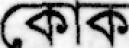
কোক
